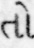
તો
